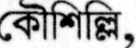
কৌশিল্লি,
